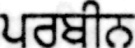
ਪਰਬੀਨ
